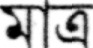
মাত্র
